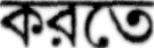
করতে
